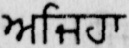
ਅਜਿਹਾ
